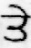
ਤੇ
